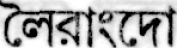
লৈরাংদো
